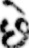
છે
